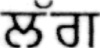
ਲੱਗ
